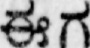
ಈಗ
